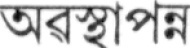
অৱস্থাপন্ন
